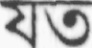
যত
